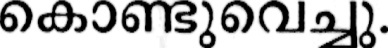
കൊണ്ടുവെച്ചു.
